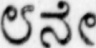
೮ನೇ
